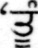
'ਤੂੰ
